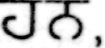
ਹਨ,
